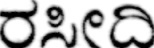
ರಸೀದಿ
